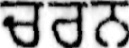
ਚਰਨ
